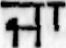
ਜਾ
